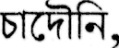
চাদৌনি,
